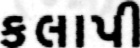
કલાપી
